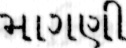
માગણી
